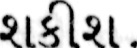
શકીશ.
